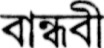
বান্ধবী
